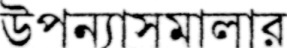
উপন্যাসমালার
